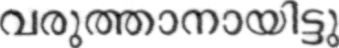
വരുത്താനായിട്ടു
